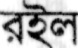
রইল
